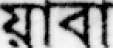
য়াবা
